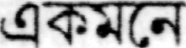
একমনে
